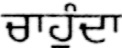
ਚਾਹੁੰਦਾ
